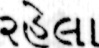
રહેલા
